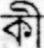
কী
